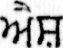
ਐਸ਼
